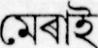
মেৰাই
